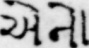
એનો
